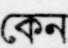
কেন
